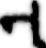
ન
